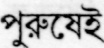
পুরুষেই
